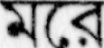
মরে
